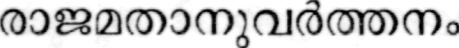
രാജമതാനുവര്‍ത്തനം
